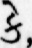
કે,
